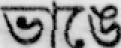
ভাঙে
